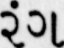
રંગ
